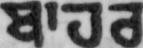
ਬਾਹਰ
